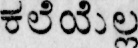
ಕಲೆಯೆಲ್ಲ
